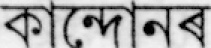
কান্দোনৰ
